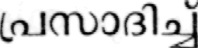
പ്രസാദിച്ച്
